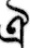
ঐ
